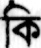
কি
